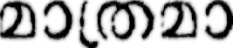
മാത്രമാ
